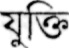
যুক্তি
